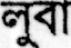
লুবা
